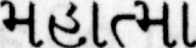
મહાત્મા
